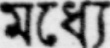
মধ্যে
